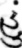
હું
